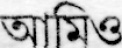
আমিও
